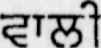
ਵਾਲੀ
